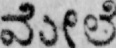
ಮೇಲೆ
